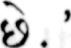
છે."
